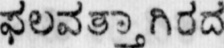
ಫಲವತ್ತಾಗಿರದ
